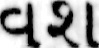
વશ
